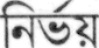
নির্ভয়
